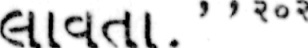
લાવતા."૨૦૨
